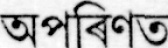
অপৰিণত
